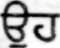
ਉਹ
